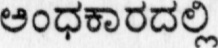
ಅಂಧಕಾರದಲ್ಲಿ
